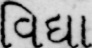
વિદ્યા
